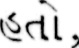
હતો,
